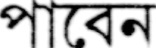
পাবেন
